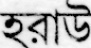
হরাউ
